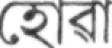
হোৱা
